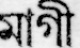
মাগী
